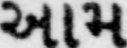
આમ
